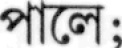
পালে;
